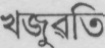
খজুৱতি
